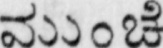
ಮುಂಚೆ
